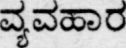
ವ್ಯವಹಾರ
